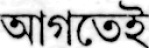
আগতেই
